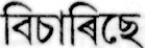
বিচাৰিছে
